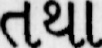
તથા
